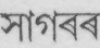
সাগৰৰ
